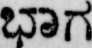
ಭಾಗ
